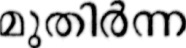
മുതിര്‍ന്ന
